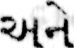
અને
